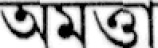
অমত্তা
